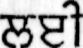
ਲਈ
